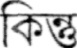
কিন্তু
